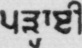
ਪੜ੍ਹਾਈ
